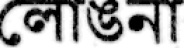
লোঙনা
